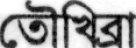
তৌখিব্রা
